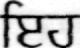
ਇਹ
